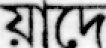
য়াদে
